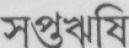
সপ্তঋষি
